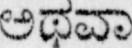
ಅಥವಾ
